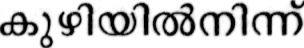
കുഴിയില്‍നിന്ന്
